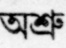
অশ্রু
